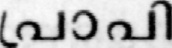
പ്രാപി
